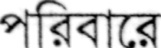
পরিবারে
